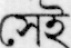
সেই
